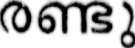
രണ്ടു
